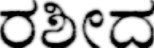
ರಶೀದ
